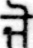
ਜੋ
